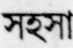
সহসা
